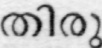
തിരു
